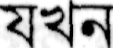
যখন
